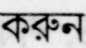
করুন
